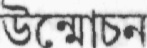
উন্মোচন
